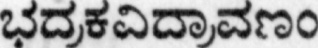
ಭದ್ರಕವಿದ್ರಾವಣಂ
